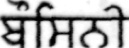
ਬੌਸਿਨੀ
